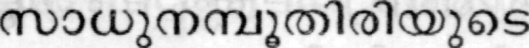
സാധുനമ്പൂതിരിയുടെ
